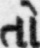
તો
